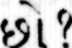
છો
